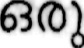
ഒരു
